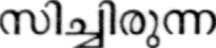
സിച്ചിരുന്ന
